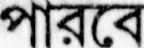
পারবে
